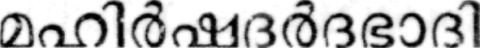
മഹിര്‍ഷദര്‍ദഭാദി
